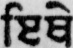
ਇਥੇ
